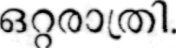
ഒറ്റരാത്രി.
